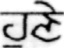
ਹੁਣੇ
